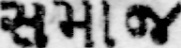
સમાજ
